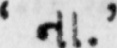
'ના.'
